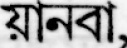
য়ানবা,
